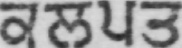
ਕਲਪਤ
